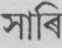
সাৰি
